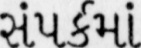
સંપર્કમાં
